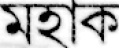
মহাক
